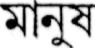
মানুষ
